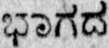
ಭಾಗದ
